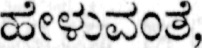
ಹೇಳುವಂತೆ,
